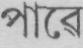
পাৱে
